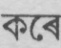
কৰে
